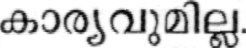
കാര്യവുമില്ല.
